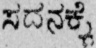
ಸದನಕ್ಕೆ
